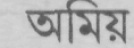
অমিয়
